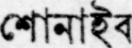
শোনাইব
